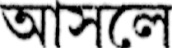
আসলে
